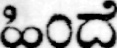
ಹಿಂದೆ
